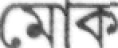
মোক
